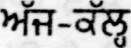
ਅੱਜ-ਕੱਲ੍ਹ
